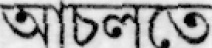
আচলতে
